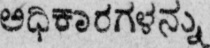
ಅಧಿಕಾರಗಳನ್ನು
